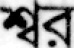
শ্বর
